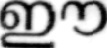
ഈ
